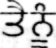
ਤੈਨੂੰ
